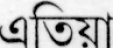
এতিয়া
